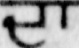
ਦਾ
